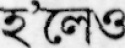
হ'লেও
